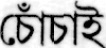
চোঁচাই
